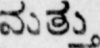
ಮತ್ತು
